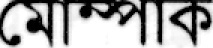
মোম্পাক
